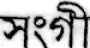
সংগী
